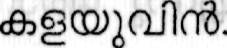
കളയുവിന്‍.
